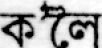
ক'লৈ
